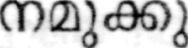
നമുക്കു
